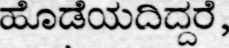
ಹೊಡೆಯದಿದ್ದರೆ,
